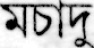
মচাদু
